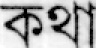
কথা
